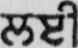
ਲਈ
